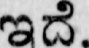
ಇದೆ.
